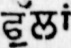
ਫੁੱਲਾਂ
